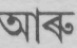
আৰু
